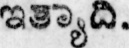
ಇತ್ಯಾದಿ.
